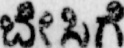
ಬೇಸಿಗೆ
